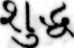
શુદ્ધ
